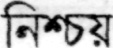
নিশ্চয়
